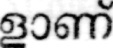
ളാണ്
